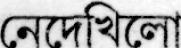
নেদেখিলো
